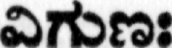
ವಿಗುಣಃ
